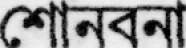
শোনবনা
